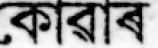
কোৱাৰ
